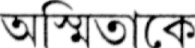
অস্মিতাকে
